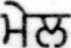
ਮੇਲ
